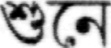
শুনে
